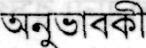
অনুভাবকী
